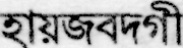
হায়জবদগী
